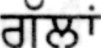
ਗੱਲਾਂ
